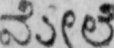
ಮೇಲೆ
